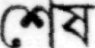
শেষ
